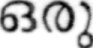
ഒരു
